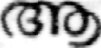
ആ
